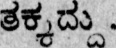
ತಕ್ಕದ್ದು.
